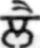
ਲੈ
